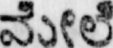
ಮೇಲೆ
